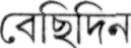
বেছিদিন
